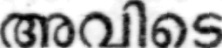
അവിടെ
